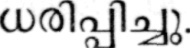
ധരിപ്പിച്ചു.
